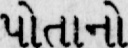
પોતાનો
